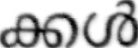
ക്കള്‍
